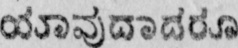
ಯಾವುದಾದರೂ
